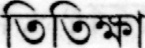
তিতিক্ষা
